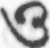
ও
